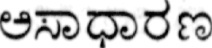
ಅಸಾಧಾರಣ
